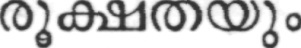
രൂക്ഷതയും
